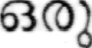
ഒരു
